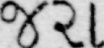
જરા
